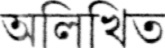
অলিখিত
